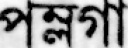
পম্লগা
